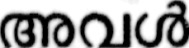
അവള്‍
